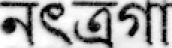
নৎত্রগা
